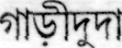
গাড়ীদুদা
